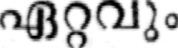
ഏറ്റവും
